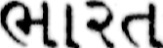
ભારત
